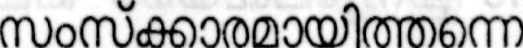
സംസ്ക്കാരമായിത്തന്നെ
